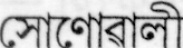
সোণোৱালী
